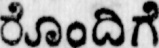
ರೊಂದಿಗೆ
